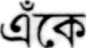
এঁকে
